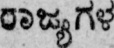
ರಾಜ್ಯಗಳ
